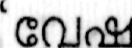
'വേഷ
